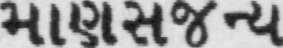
માણસજન્ય
